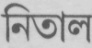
নিতাল
